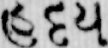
હદય
